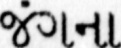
જંગના
